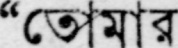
‘‘তোমার
